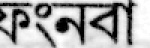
ফংনবা
